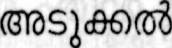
അടുക്കല്‍
